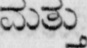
ಮತ್ತು
